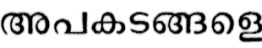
അപകടങ്ങളെ
